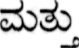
ಮತ್ತು
